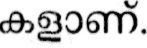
കളാണ്.
